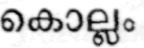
കൊല്ലം
